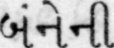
બંનેની
